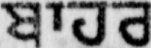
ਬਾਹਰ
